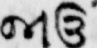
જાઉં
